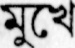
মুখে
